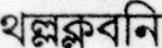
থল্লক্লবনি
